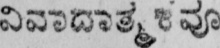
ವಿವದಾತ್ಮಕವೂ
